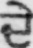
ਦੇ
